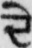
ਦੇ
